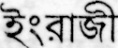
ইংরাজী
